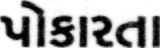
પોકારતા
